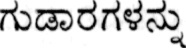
ಗುಡಾರಗಳನ್ನು
